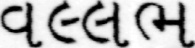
વલ્લભ
